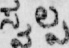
ಸ್ವಲ್ಪ
